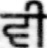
ਵੀ
